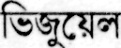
ভিজুয়েল
